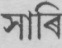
সাৰি
